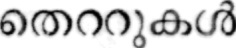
തെററുകള്‍
